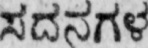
ಸದನಗಳ
